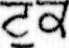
ਟੁਕ
